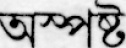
অস্পষ্ট
